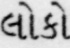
લોકો
